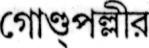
গোণ্ড্পল্লীর
